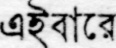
এইবারে
